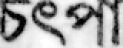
চৎপা
